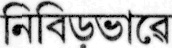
নিবিড়ভাৱে
